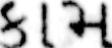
કામ
